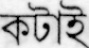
কটাই
